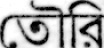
তৌরি
